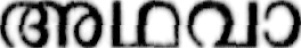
അഥവാ
